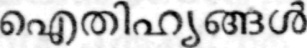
ഐതിഹ്യങ്ങള്‍
